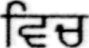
ਵਿਚ
